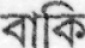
বাকি
